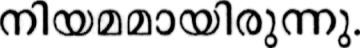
നിയമമായിരുന്നു.
